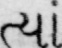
ત્યાં
